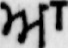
ਆ
